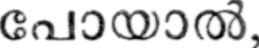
പോയാല്‍,
